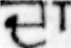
ਦਾ
